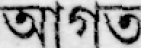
আগত
